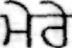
ਮੇਰੇ
